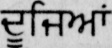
ਦੂਜਿਆਂ
